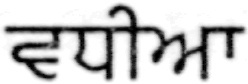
ਵਧੀਆ
